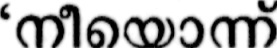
‘നീയൊന്ന്
